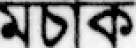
মচাক
